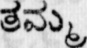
ತಮ್ಮ
